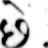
છે.
